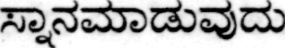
ಸ್ನಾನಮಾಡುವುದು
